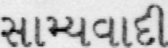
સામ્યવાદી
